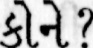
કોને?
